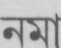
নমা
